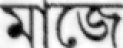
মাজে
